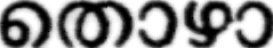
തൊഴാ
